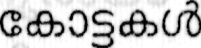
കോട്ടകള്‍
